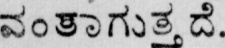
ವಂತಾಗುತ್ತದೆ.
